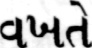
વખતે
